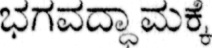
ಭಗವದ್ಧಾಮಕ್ಕೆ
